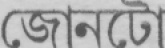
জোনটো
